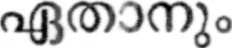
ഏതാനും
